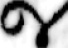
જ
